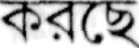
করছে
